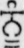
ਨੂੰ
